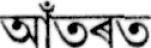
আঁতৰত
